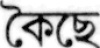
কৈছে
